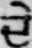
ਦੇ
